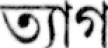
ত্যাগ
